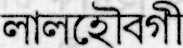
লালহৌবগী
